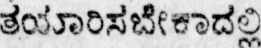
ತಯಾರಿಸಬೇಕಾದಲ್ಲಿ
